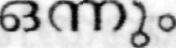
ഒന്നും
